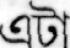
এটা
